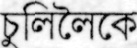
চুলিলৈকে
